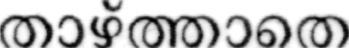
താഴ്ത്താതെ
